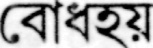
বোধহয়
